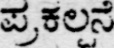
ಪ್ರಕಲ್ಪನೆ
